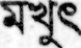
মখুৎ
